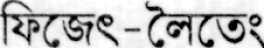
ফিজেৎ-লৈতেং
